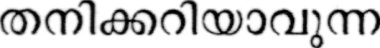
തനിക്കറിയാവുന്ന
